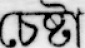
চেষ্টা
